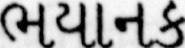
ભયાનક
